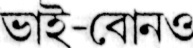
ভাই-বোনও
